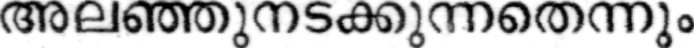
അലഞ്ഞുനടക്കുന്നതെന്നും
